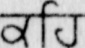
ਕਹਿ
